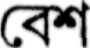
বেশ
